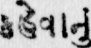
કહેવાનું
